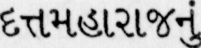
દત્તમહારાજનું
